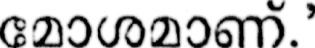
മോശമാണ്.’
